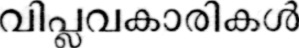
വിപ്ലവകാരികള്‍
